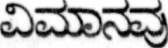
ವಿಮಾನವು
